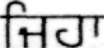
ਜਿਹਾ
